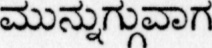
ಮುನ್ನುಗ್ಗುವಾಗ
